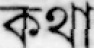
কথা
